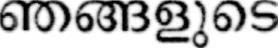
ഞങ്ങളുടെ
